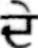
ਦੇ
